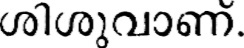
ശിശുവാണ്.
